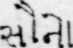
સૌનો
